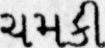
ચમકી
